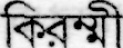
কিরম্মী
